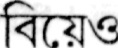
বিয়েও
